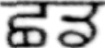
ਛਡ
